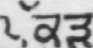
ਪੱਕੜ
